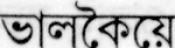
ভালকৈয়ে
